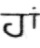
ਹਾਂ
